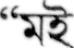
"মই
